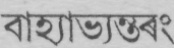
বাহ্যাভ্যন্তৰং
